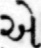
એ
